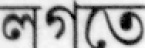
লগতে
